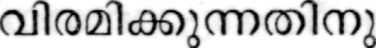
വിരമിക്കുന്നതിനു
